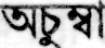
অচুম্বা
